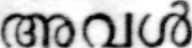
അവള്‍
